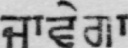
ਜਾਵੇਗਾ
